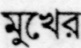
মুখের
